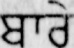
ਬਾਰੇ
